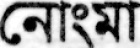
নোংমা
